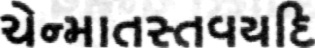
ચેન્માતસ્તવયદિ
